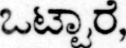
ಒಟ್ಟಾರೆ,
